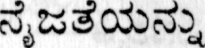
ನೈಜತೆಯನ್ನು
